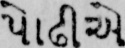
પોઢીએ
